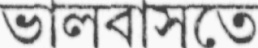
ভালবাসতে
